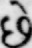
છે
